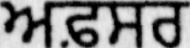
ਅਫ਼ਸਰ
